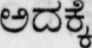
ಅದಕ್ಕೆ
